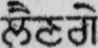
ਲੈਣਗੇ
